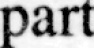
part
